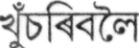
খুঁচৰিবলৈ
